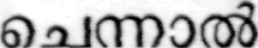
ചെന്നാല്‍
